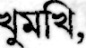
খুমখি,
